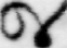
જ
